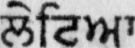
ਲੇਟਿਆ
